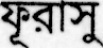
ফূরাসু
